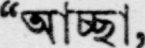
‘‘আচ্ছা,
